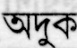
অদুক
